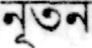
নূতন
